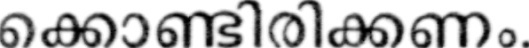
ക്കൊണ്ടിരിക്കണം.
